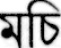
মচি
